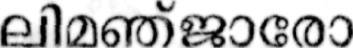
ലിമഞ്ജാരോ
